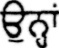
ਉਨ੍ਹਾਂ
